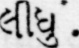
લીધું.
